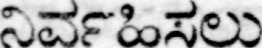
ನಿರ್ವಹಿಸಲು
